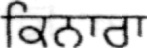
ਕਿਨਾਰਾ
